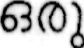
ഒരു
